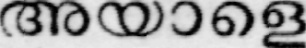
അയാളെ
